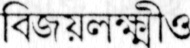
বিজয়লক্ষ্মীও
